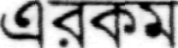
এরকম
